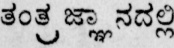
ತಂತ್ರಜ್ಞಾನದಲ್ಲಿ
